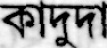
কাদুদা
